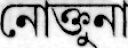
নোক্তুনা
